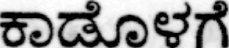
ಕಾಡೊಳಗೆ
